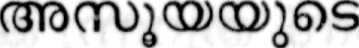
അസൂയയുടെ
